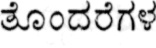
ತೊಂದರೆಗಳ
